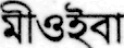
মীওইবা
